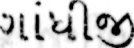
ગાંધીજી
